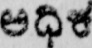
ಅಧಿಕ
